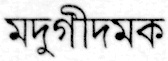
মদুগীদমক
